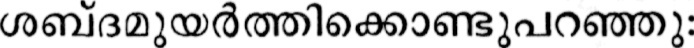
ശബദമുയര്‍ത്തിക്കൊണ്ടുപറഞ്ഞു:
